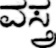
ವಸ್ತ್ರ
